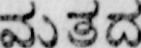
ಮತದ
